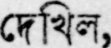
দেখিল,
